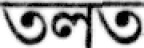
তলত
